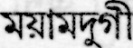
ময়ামদুগী
